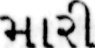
મારી
